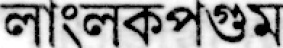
লাংলকপগুম
